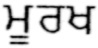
ਮੂਰਖ
